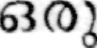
ഒരു
